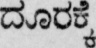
ದೂರಕ್ಕೆ
